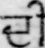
ਦੀ
